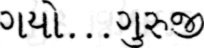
ગયો...ગુસુજી
